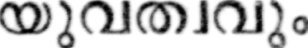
യുവത്വവും
